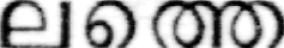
ലത്തെ
